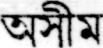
অসীম
